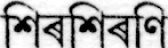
শিৰশিৰণি
